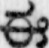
ಈ
